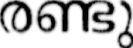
രണ്ടു
